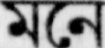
মনে
